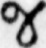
જ
